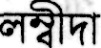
লম্বীদা
